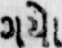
ગયો
